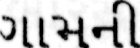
ગામની
